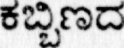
ಕಬ್ಬಿಣದ
